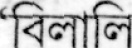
'বিলালি
